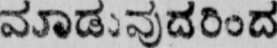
ಮಾಡುವುದರಿಂದ
